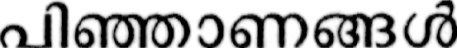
പിഞ്ഞാണങ്ങള്‍
